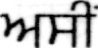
ਅਸੀਂ
